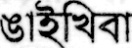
ঙাইখিবা
